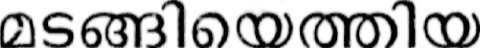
മടങ്ങിയെത്തിയ
